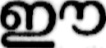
ഈ
